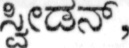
ಸ್ವೀಡನ್,
